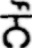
ਨੌ
